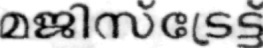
മജിസ്ട്രേട്ട്
